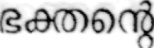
ഭക്തന്റെ
